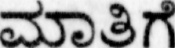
ಮಾತಿಗೆ
